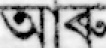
আৰু
